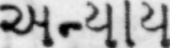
અન્યાય
